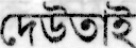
দেউতাই
